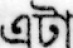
এটা
